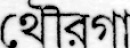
থৌরগা
